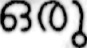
ഒരു
